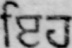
ਇਹ
